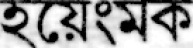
হয়েংমক
